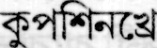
কুপশিনখ্রে
